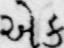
એક
